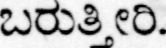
ಬರುತ್ತೀರಿ.
